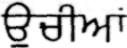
ਉਚੀਆਂ
